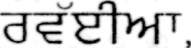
ਰਵੱਈਆ,
